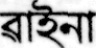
ৱাইনা
